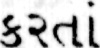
કરતાં
